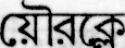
য়ৌরক্লে
